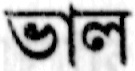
ভাল
